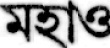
মহাও
